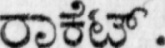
ರಾಕೆಟ್.
